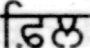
ਫ਼ਿਲ
